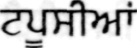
ਟਪੂਸੀਆਂ
